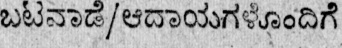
ಬಟವಾಡೆ/ಆದಾಯಗಳೊಂದಿಗೆ
